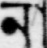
না
